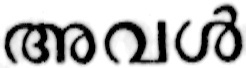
അവള്‍
